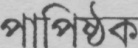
পাপিষ্ঠক
